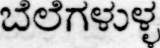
ಬೆಲೆಗಳುಳ್ಳ
